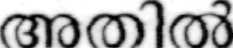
അതില്‍
